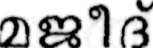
മജീദ്
